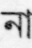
না
